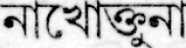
নাখোক্তুনা
